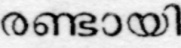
രണ്ടായി
